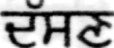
ਦੱਸਣ
